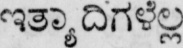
ಇತ್ಯಾದಿಗಳೆಲ್ಲ
